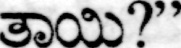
ತಾಯಿ?"
